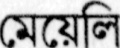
মেয়েলি
